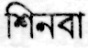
শিনবা
